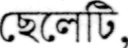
ছেলেটি,
